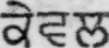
ਕੇਵਲ
